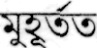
মুহূর্তত
